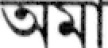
অমা
